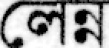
লেন্ন
